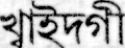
খ্বাইদগী
